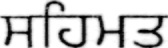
ਸਹਿਮਤ
